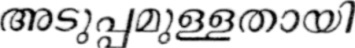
അടുപ്പമുള്ളതായി
